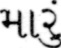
મારું
